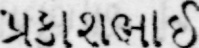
પ્રકાશભાઈ
